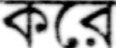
করে
